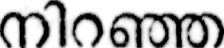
നിറഞ്ഞ
